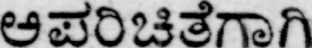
ಅಪರಿಚಿತೆಗಾಗಿ
